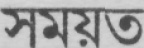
সময়ত
